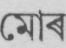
মোৰ
